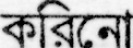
করিনো
